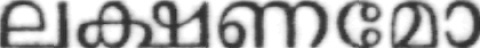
ലക്ഷണമോ
